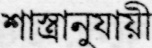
শাস্ত্রানুযায়ী
